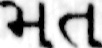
મત
